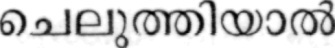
ചെലുത്തിയാല്‍
